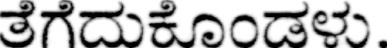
ತೆಗೆದುಕೊಂಡಳು.
